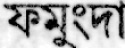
ফমুংদা
